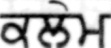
ਕਲੇਮ
